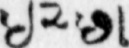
ઈચ્છા
